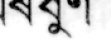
বৰষুণ
